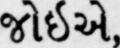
જોઈએ,
